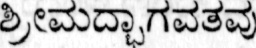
ಶ್ರೀಮದ್ಭಾಗವತವು
